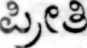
ಪ್ರೀತಿ
